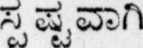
ಸ್ಪಷ್ಟವಾಗಿ
